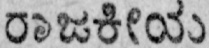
ರಾಜಕೀಯ
